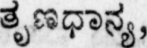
ತೃಣಧಾನ್ಯ,
